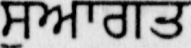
ਸੁਆਗਤ
